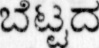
ಬೆಟ್ಟದ
